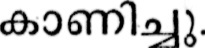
കാണിച്ചു.
